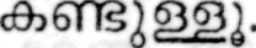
കണ്ടുള്ളൂ.
